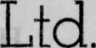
Ltd.
